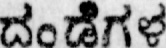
ದಂಡೆಗಳ
